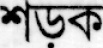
শড়ক
